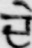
ਦੇ
